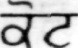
ਕੋਟ
